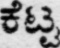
ಕೆಟ್ಟ
